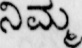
ನಿಮ್ಮ
